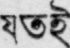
যতই
